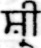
ਸ਼੍ਰੀ
